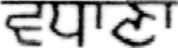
ਵਧਾਣਾ
